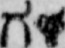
ಗಳ
